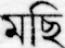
মছি
